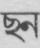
ছন
